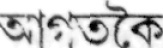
আগতকৈ
